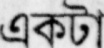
একটা
